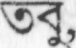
তবু,
